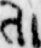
તો
